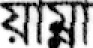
য়াম্না
